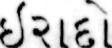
ઇરાદો
